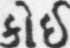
કોઈ
